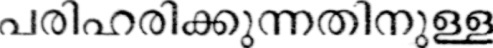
പരിഹരിക്കുന്നതിനുള്ള
